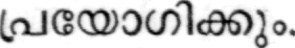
പ്രയോഗിക്കും.
